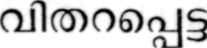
വിതറപ്പെട്ട
